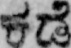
ಕಡೆ
